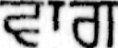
ਵਾਗ
